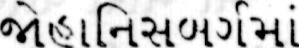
જોહાનિસબર્ગમાં
